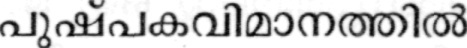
പുഷ്പകവിമാനത്തില്‍
